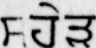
ਸਹੇੜ
